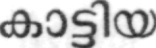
കാട്ടിയ
